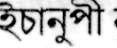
‘ইচানুপী
